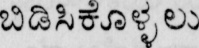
ಬಿಡಿಸಿಕೊಳ್ಳಲು
